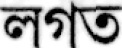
লগত
